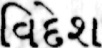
વિદેશ
